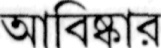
আবিষ্কার
